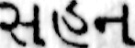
સહન
